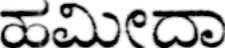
ಹಮೀದಾ
